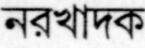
নরখাদক
